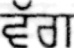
ਵੱਗ
